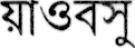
য়াওবসু
